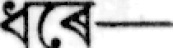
ধৰে-
